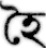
হৈ
